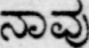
ನಾವು
